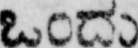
ಒಂದು
